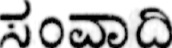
ಸಂವಾದಿ
